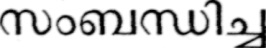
സംബന്ധിച്ച
